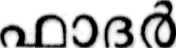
ഫാദര്‍
